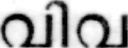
വിവ
